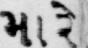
મારે
